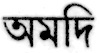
অমদি
